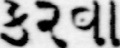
કરવા
